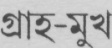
গ্ৰাহ-মুখ
